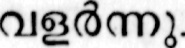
വളര്‍ന്നു.
